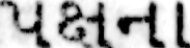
પક્ષના
